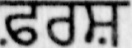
ਫ਼ਰਸ਼
